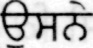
ਉਸਨੇ
